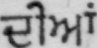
ਦੀਆਂ
